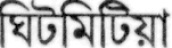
ঘিটমিটিয়া
